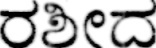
ರಶೀದ
